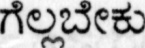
ಗೆಲ್ಲಬೇಕು
